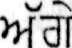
ਅੱਗੇ
